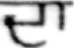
ਦਾ
